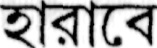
হারাবে
